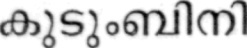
കുടുംബിനി
